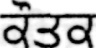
ਕੌਤਕ
